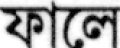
ফালে
